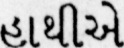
હાથીએ
